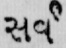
સર્વ
